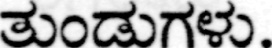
ತುಂಡುಗಳು.
